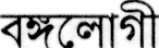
বঙ্গলোগী
